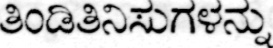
ತಿಂಡಿತಿನಿಸುಗಳನ್ನು
